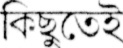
কিছুতেই
